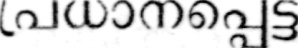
പ്രധാനപ്പെട്ട
